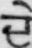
ਦੇ
